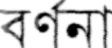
বর্ণনা
